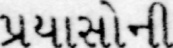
પ્રયાસોની
